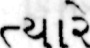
ત્યારે
